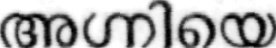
അഗ്നിയെ
